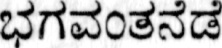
ಭಗವಂತನೆಡೆ
